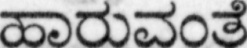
ಹಾರುವಂತೆ
